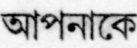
আপনাকে
